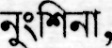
নুংশিনা,
